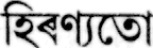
হিৰণ্যতো
